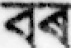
বৰ
